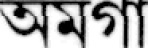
অমগা
